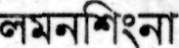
লমনশিংনা
